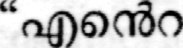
“എന്റെ
